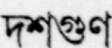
দশগুণ
